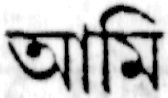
আমি
